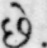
છે.
